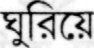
ঘুরিয়ে
